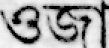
ওজা
